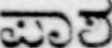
ಪಾಶ
